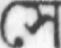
সে
